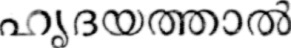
ഹൃദയത്താല്‍
